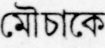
মৌচাকে
